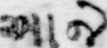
આજે
